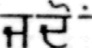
ਜਦੋਂ
